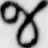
જ
